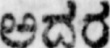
ಅದರ
